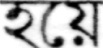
হয়ে
